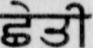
ਛੇਤੀ
